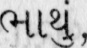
ભાથું,
